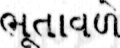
ભૂતાવળે
